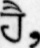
ਹੈ,
